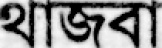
থাজবা
